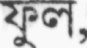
ফুল,
